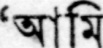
‘আমি
